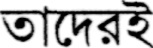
তাদেরই
